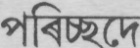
পৰিচ্ছদে
